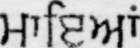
ਮਾਇਆਂ
